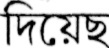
দিয়েছ
